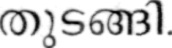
തുടങ്ങി.
